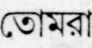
তোমরা
